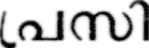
പ്രസി
